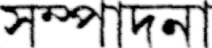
সম্পাদনা
